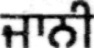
ਜਾਨੀ
